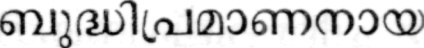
ബുദ്ധിപ്രമാണനായ
